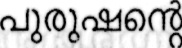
പുരുഷന്റെ
